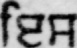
ਇਸ
